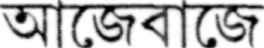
আজেবাজে
